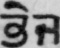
ਭੇਜ
